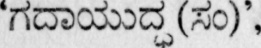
‘ಗದಾಯುದ್ಧ(ಸಂ)’,
